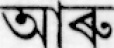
আৰু
